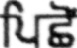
ਪਿਛੋਂ
